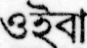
ওইবা
